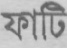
ফাটি
